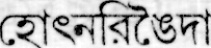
হোৎনরিঙৈদা
